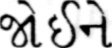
જોઈને
